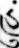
હું
